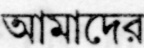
আমাদের
